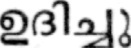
ഉദിച്ചു
